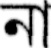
না
